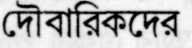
দৌবারিকদের
